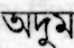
অদুম
